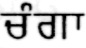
ਚੰਗਾ
